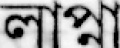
লাপ্না
